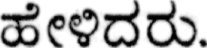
ಹೇಳಿದರು.
